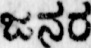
ಜನರ
